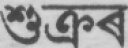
শুক্ৰৰ
